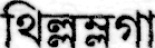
থিল্লম্লগা
